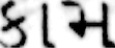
કામ
